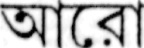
আরো
